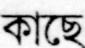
কাছে
